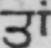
ਤਾਂ
